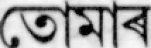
তোমাৰ
